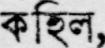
কহিল,
